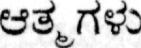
ಆತ್ಮಗಳು
